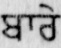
ਬਾਰੇ
